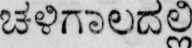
ಚಳಿಗಾಲದಲ್ಲಿ
